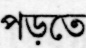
পড়তে
